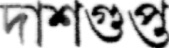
দাশগুপ্ত
